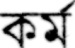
কর্ম
